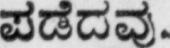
ಪಡೆದವು.
